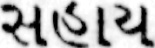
સહાય
